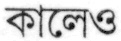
কালেও
